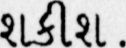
શકીશ.
